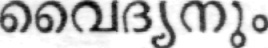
വൈദ്യനും
